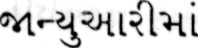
જાન્યુઆરીમાં
